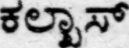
ಕಲ್ಖಾಸ್
